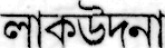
লাকউদনা
